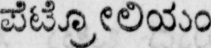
ಪೆಟ್ರೋಲಿಯಂ
